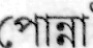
পোন্না
